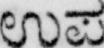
ಉಪ
